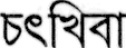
চৎখিবা
